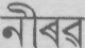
নীৰৱ
